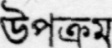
উপক্রম
